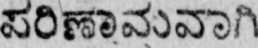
ಪರಿಣಾಮವಾಗಿ
